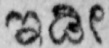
ಇಡೀ
